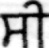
ਸੀ
